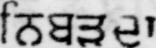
ਨਿਬੜਦਾ
